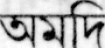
অমদি
